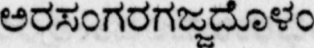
ಅರಸಂಗರಗಜ್ಜದೊಳಂ
